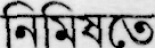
নিমিষতে
